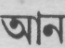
আন
